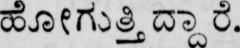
ಹೋಗುತ್ತಿದ್ದಾರೆ.
